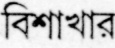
বিশাখার
